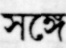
সঙ্গে
